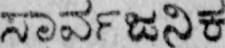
ಸಾರ್ವಜನಿಕ
